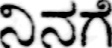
ನಿನಗೆ
